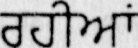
ਰਹੀਆਂ
